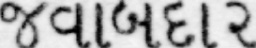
જવાબદાર
